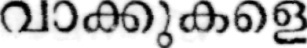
വാക്കുകളെ
